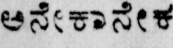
ಅನೇಕಾನೇಕ
